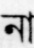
না
